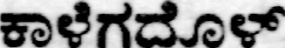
ಕಾಳೆಗದೊಳ್
